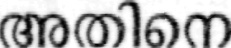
അതിനെ
